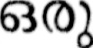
ഒരു
